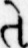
તે
